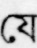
যে
